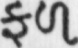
ફળ
